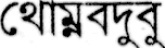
থোম্নবদুবু
